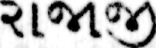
રાજાજી
